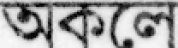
অকলে
